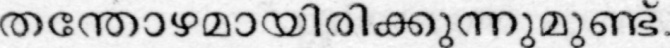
തന്തോഴമായിരിക്കുന്നുമുണ്ട്.
